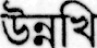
উন্নখি
